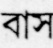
বাস
